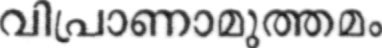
വിപ്രാണാമുത്തമം
